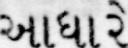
આધારે
